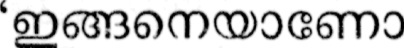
‘ഇങ്ങനെയാണോ
